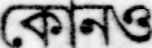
কোনও
